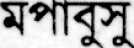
মপাবুসু
